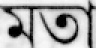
মতা
